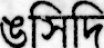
ঙসিদি
